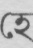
হে
